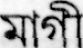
মাগী
